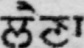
ਲੈਣਾ
